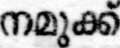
നമുക്ക്
